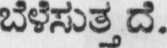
ಬೆಳೆಸುತ್ತದೆ.
